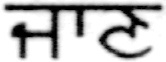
ਜਾਣ
